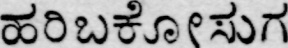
ಹರಿಬಕೋಸುಗ
